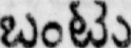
ಬಂಟು
